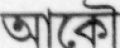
আকৌ
